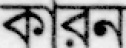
কারন
